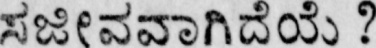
ಸಜೀವವಾಗಿದೆಯೆ?
